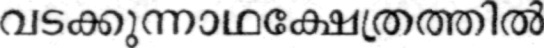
വടക്കുന്നാഥക്ഷേത്രത്തില്‍
